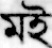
মই
